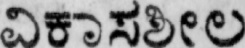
ವಿಕಾಸಶೀಲ
